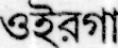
ওইরগা
